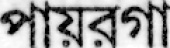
পায়রগা
